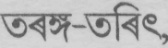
তৰঙ্গ-তৰিৎ,
